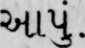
આપું.
